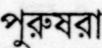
পুরুষরা
